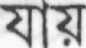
যায়
